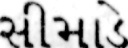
સીમાડે
